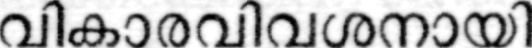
വികാരവിവശനായി
